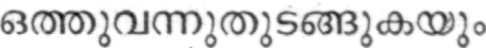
ഒത്തുവന്നുതുടങ്ങുകയും
